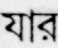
যার
